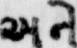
અને
